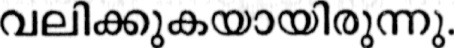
വലിക്കുകയായിരുന്നു.
